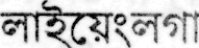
লাইয়েংলগা
